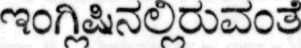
ಇಂಗ್ಲಿಷಿನಲ್ಲಿರುವಂತೆ
